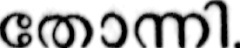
തോന്നി.
